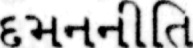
દમનનીતિ
